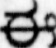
ಈ
